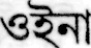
ওইনা
